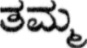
ತಮ್ಮ
